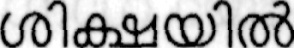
ശിക്ഷയില്‍
